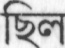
ছিল
